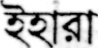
ইহারা
